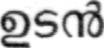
ഉടന്‍
